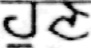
ਹੁਣ
